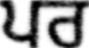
ਪਰ
